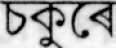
চকুৰে
